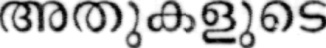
അതുകളുടെ
